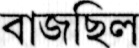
বাজছিল
